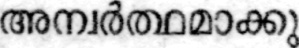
അന്വര്‍ത്ഥമാക്കു
